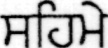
ਸਹਿਮੇ
